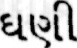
ઘણી
